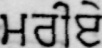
ਮਰੀਏ
